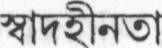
স্বাদহীনতা
